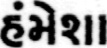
હંમેશા
